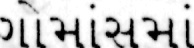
ગોમાંસમાં
